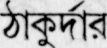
ঠাকুর্দার
